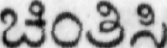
ಚಿಂತಿಸಿ
